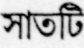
সাতটি
